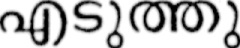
എടുത്തു
